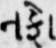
નફો
